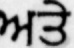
ਅਤੇ
